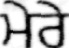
ਮੇਰੇ
